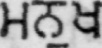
ਮਨੁਖ
